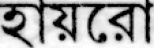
হায়রো
